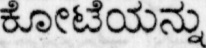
ಕೋಟೆಯನ್ನು
